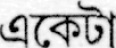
একেটা
